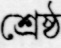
শ্রেষ্ঠ
